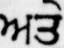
ਅਤੇ
